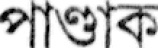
পাণ্ডাক
